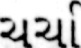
ચર્ચા
